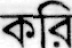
করি
